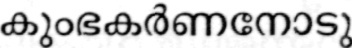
കുംഭകര്‍ണനോടു
